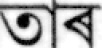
তাৰ
